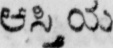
ಆಸ್ತಿಯ
